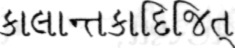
કાલાન્તકાદિજિત્
